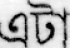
এটা
